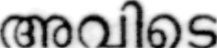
അവിടെ
